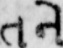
તને
